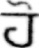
ਹੋ
